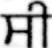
ਸੀ
